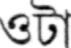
ওটা
